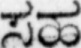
ಸಹ
